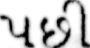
પછી
